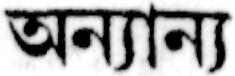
অন্যান্য
